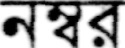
নম্বর
